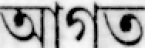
আগত
